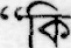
"কি
